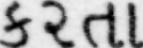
કરતા
